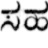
ಸಹ
